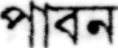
পাবন
